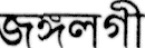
জঙ্গলগী
